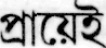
প্রায়েই
